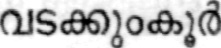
വടക്കുംകൂര്‍
